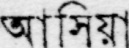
আসিয়া
